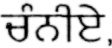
ਚੰਨੀਏ,
